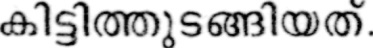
കിട്ടിത്തുടങ്ങിയത്.
